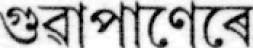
গুৱাপাণেৰে
